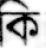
কি
